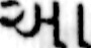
આ
